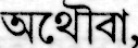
অথৌবা,
